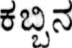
ಕಬ್ಬಿನ
